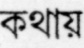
কথায়
